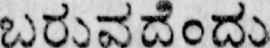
ಬರುವದೆಂದು
